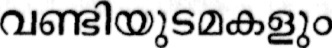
വണ്ടിയുടമകളും
